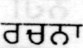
ਰਚਨਾ
